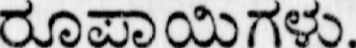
ರೂಪಾಯಿಗಳು.
